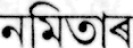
নমিতাৰ
